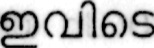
ഇവിടെ
